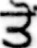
ਤੋਂ
